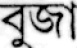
বুজা
